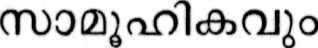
സാമൂഹികവും
